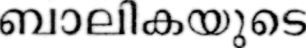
ബാലികയുടെ
